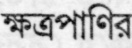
ক্ষত্রপাণির
